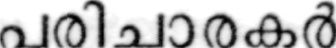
പരിചാരകര്‍
